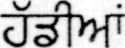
ਹੱਡੀਆਂ
